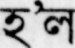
হ'ল
